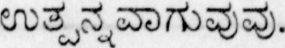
ಉತ್ಪನ್ನವಾಗುವುವು.
